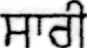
ਸਾਰੀ
